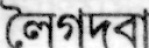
লৈগদবা
